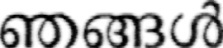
ഞങ്ങള്‍
